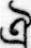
ঐ
